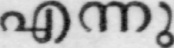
എന്നു
